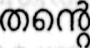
തന്റെ
